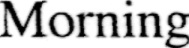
Morning
